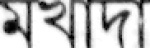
মখাদা
